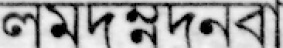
লমদম্নদনবা
